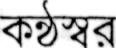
কন্ঠস্বর
